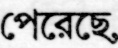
পেরেছে,
